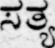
ಸತ್ಯ
